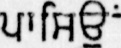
ਪਾਸਿਉਂ
